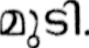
മുടി.
